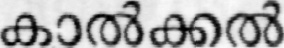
കാല്‍ക്കല്‍
